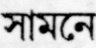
সামনে
